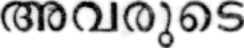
അവരുടെ
